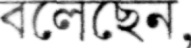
বলেছেন,
